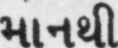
માનથી
